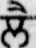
ਲੈ
